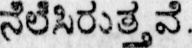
ನೆಲೆಸಿರುತ್ತವೆ.
